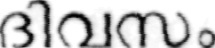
ദിവസം
